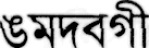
ঙমদবগী
